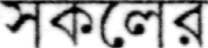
সকলের
